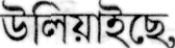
উলিয়াইছে,
